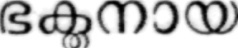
ഭക്തനായ
